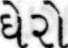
ઘેરો
